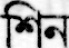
শিন
